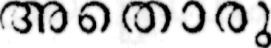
അതൊരു
